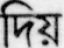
দিয়
